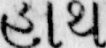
હાથ
